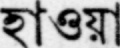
হাওয়া
